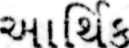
આર્થિક
